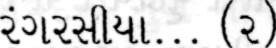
રંગરસીયારે...(૨)
